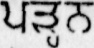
ਪੜ੍ਹਨ
